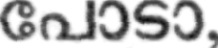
പോടാ,
